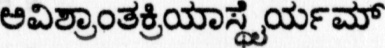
ಅವಿಶ್ರಾ೦ತಕ್ರಿಯಾಸ್ಥೈರ್ಯಮ್
